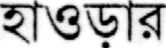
হাওড়ার
